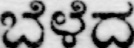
ಬೆಳೆದ
